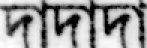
দাদাদা
